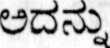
ಅದನ್ನು
